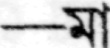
–মা
